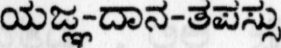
ಯಜ್ಞ-ದಾನ-ತಪಸ್ಸು
